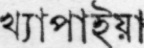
খ্যাপাইয়া
